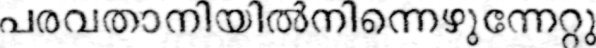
പരവതാനിയില്‍നിന്നെഴുന്നേറ്റു
